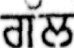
ਗੱਲ
